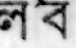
ল'ব
